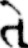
તે
